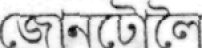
জোনটোলৈ
